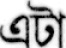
এটা
